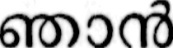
ഞാന്‍
